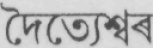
দৈত্যেশ্বৰ
